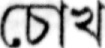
চোখ
